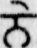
ਨੇ
